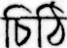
চিঠি
